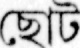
ছোট
